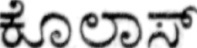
ಕೊಲಾಸ್
